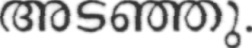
അടഞ്ഞു.
